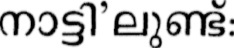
നാട്ടി’ലുണ്ട്:
